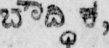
ಭೌದ್ಧಿಕ,
